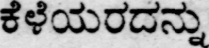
ಕೆಳೆಯರದನ್ನು
